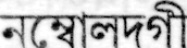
নম্বোলদগী
